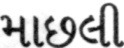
માછલી
